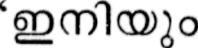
'ഇനിയും
